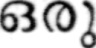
ഒരു
